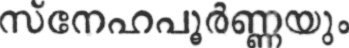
സ്നേഹപൂര്‍ണ്ണയും
